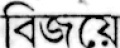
বিজয়ে
